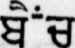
ਬੈਂਚ
